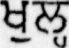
ਖੁਲ੍ਹ
